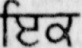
ਇਕ
